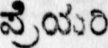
ಪ್ರೆಯರಿ
